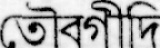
তৌবগীদি
